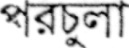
পরচুলা
